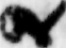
જ
